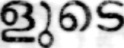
ളുടെ
